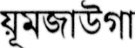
য়ূমজাউগা
